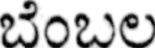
ಬೆಂಬಲ
